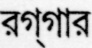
রগ্গার
